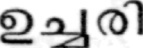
ഉച്ചരി
